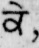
ਕੇ,
